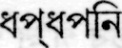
ধপ্‌ধপনি
